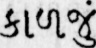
કાળજું
